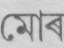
মোৰ
